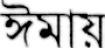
ঈমায়
